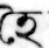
হৈ
